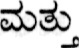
ಮತ್ತು
